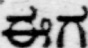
ಈಗ
